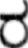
ರ
